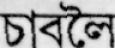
চাবলৈ
